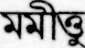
মমীত্তু
